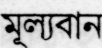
মূল্যবান
